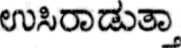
ಉಸಿರಾಡುತ್ತಾ
